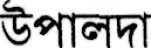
উপালদা
